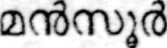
മന്‍സൂര്‍
